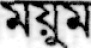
ময়ুম
